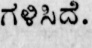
ಗಳಿಸಿದೆ.
